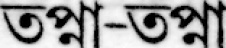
তপ্না-তপ্না
